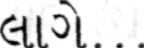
લાગે...
